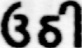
ઉઠી
